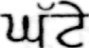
ਘੱਟੇ
